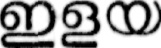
ഇളയ
